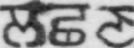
ਲਛਣ
